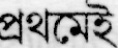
প্রথমেই
